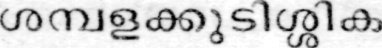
ശമ്പളക്കുടിശ്ശിക
